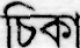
চিকা
